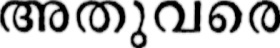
അതുവരെ
